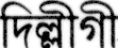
দিল্লীগী
